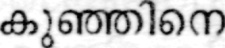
കുഞ്ഞിനെ
